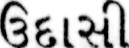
ઉદાસી
